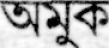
অমুক
